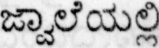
ಜ್ವಾಲೆಯಲ್ಲಿ
